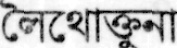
লৈথোক্তুনা
